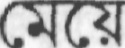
মেয়ে
